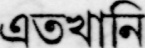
এতখানি
